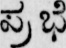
ಪ್ರಭೆ
